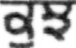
ਕੁਝ
